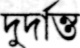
দুর্দান্ত
